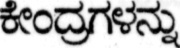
ಕೇಂದ್ರಗಳನ್ನು
